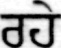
ਰਹੇ
